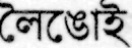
লৈঙোই
